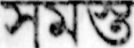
সমস্ত
